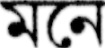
মনে
